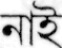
নাই
